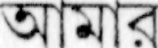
আমার
